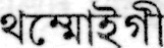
থম্মোইগী
